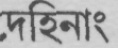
দেহিনাং
